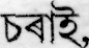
চৰাই,
